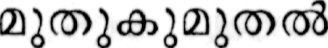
മുതുകുമുതല്‍
